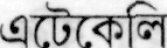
এটেকেলি
